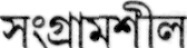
সংগ্রামশীল
